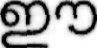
ഈ
